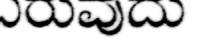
ಬರುವುದು
